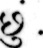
છું.
